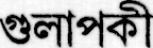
ণ্ডলাপকী
